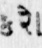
કરો
